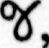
જ,
